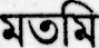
মতমি
